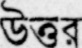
উত্তর
